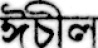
ঈচীল
